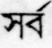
সর্ব
